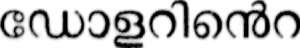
ഡോളറിന്റെ
